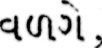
વળગે,
